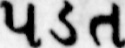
પડત
